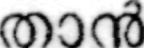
താന്‍
